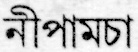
নীপামচা
